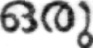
ഒരു
